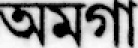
অমগা
